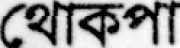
থোকপা
